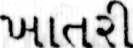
ખાતરી
